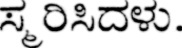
ಸ್ಮರಿಸಿದಳು.
